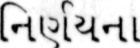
નિર્ણયના
